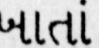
ખાતાં
